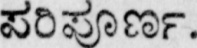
ಪರಿಪೂರ್ಣ.
